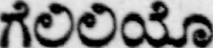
ಗೆಲಿಲಿಯೊ
